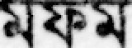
মফম
